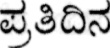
ಪ್ರತಿದಿನ
